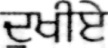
ਦੁਖੀਏ
